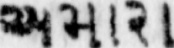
અમારા
